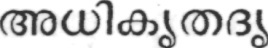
അധികൃതദൃ
